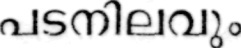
പടനിലവും
